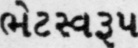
ભેટસ્વરૂપ
